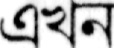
এখন
